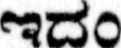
ಇದಂ
